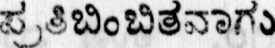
ಪ್ರತಿಬಿಂಬಿತವಾಗು
